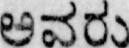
ಅವರು
